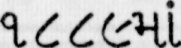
૧૮૮૯માં
